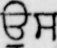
ਉਸ
